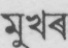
মুখৰ
